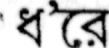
ধ'রে
